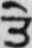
ਤੇ
